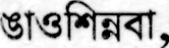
ঙাওশিন্নবা,
